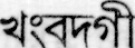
খংবদগী
